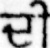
ਦੀ
